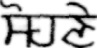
ਸੋਹਣੇ
